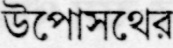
উপোসথের
